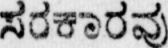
ಸರಕಾರವು
